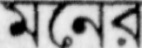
মনের
